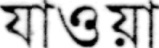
যাওয়া
